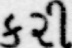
કરી
